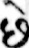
છે
